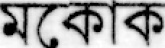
মকোক
